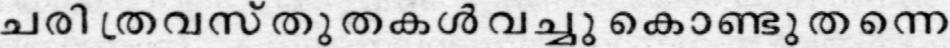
ചരിത്രവസ്തുതകള്‍വച്ചുകൊണ്ടുതന്നെ
